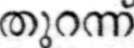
തുറന്ന്
